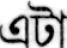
এটা
